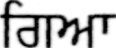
ਗਿਆ
